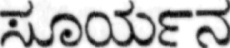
ಸೂರ್ಯನ
